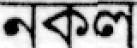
নকল
